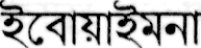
ইবোয়াইমনা
